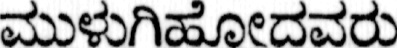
ಮುಳುಗಿಹೋದವರು
